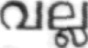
വല്ല
